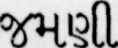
જમણી
